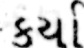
કર્યા
